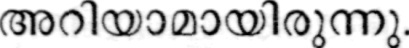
അറിയാമായിരുന്നു.
